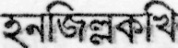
হনজিল্লকখি
